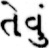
તેવું
